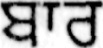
ਬਾਰ
